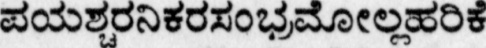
ಪಯಶ್ಚರನಿಕರಸಂಭ್ರಮೋಲ್ಲಹರಿಕೆ
